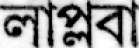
লাপ্লবা
